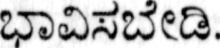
ಭಾವಿಸಬೇಡಿ.
